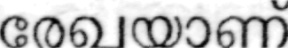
രേഖയാണ്
